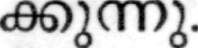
ക്കുന്നു.
